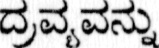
ದ್ರವ್ಯವನ್ನು
